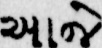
આજે
